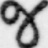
જ
